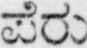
ಪೆರು
